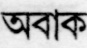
অবাক
